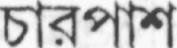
চারপাশ
